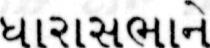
ધારાસભાને
